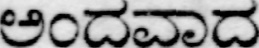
ಅಂದವಾದ
